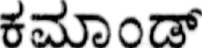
ಕಮಾಂಡ್
